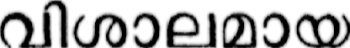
വിശാലമായ
